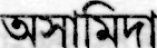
অসামিদা
